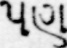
પણ
